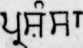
ਪ੍ਰਸ਼ੰਸਾ
